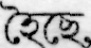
হৈছে,
